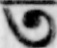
ত
